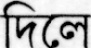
দিলে
